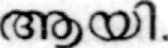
ആയി.
